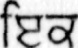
ਇਕ
